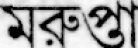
মরুপ্তা
